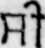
ਸੀ
